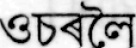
ওচৰলৈ
